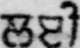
ਲਈ
